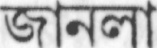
জানলা
